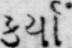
કર્યા
